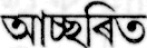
আচ্ছৰিত
